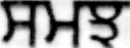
ਸਮਝ
